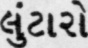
લુંટારો
